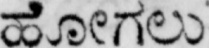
ಹೋಗಲು
